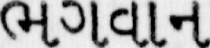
ભગવાન
